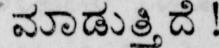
ಮಾಡುತ್ತಿದೆ!
